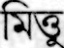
মিত্তু
